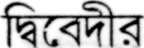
দ্বিবেদীর
